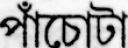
পাঁচোটা
